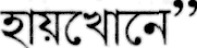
হায়খোনে”
